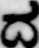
ದ
